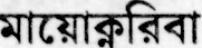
মায়োক্নরিবা
